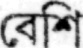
বেশি
